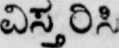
ವಿಸ್ತರಿಸಿ
